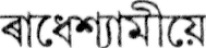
ৰাধেশ্যামীয়ে
